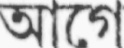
আগে
